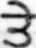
ਤੇ
